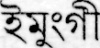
ইমুংগী
